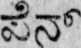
ಪೆನ್
